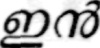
ഇന്‍
